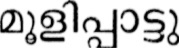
മൂളിപ്പാട്ടു
